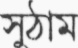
সুঠাম
